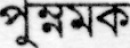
পুম্নমক
